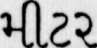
મીટર
